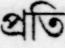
প্রতি
